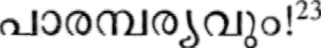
പാരമ്പര്യവും!23
